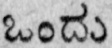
ಒಂದು
